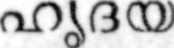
ഹൃദയ
